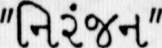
"નિરંજન
